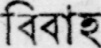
বিবাহ
